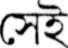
সেই
